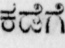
ಕಡೆಗೆ
